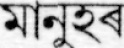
মানুহৰ
